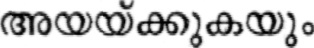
അയയ്ക്കുകയും
